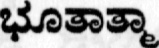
ಭೂತಾತ್ಮಾ
